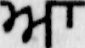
ਆ
